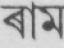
ৰাম
